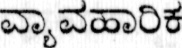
ವ್ಯಾವಹಾರಿಕ
